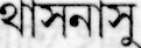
থাসনাসু
